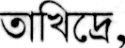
তাখিদ্রে,
